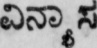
ವಿನ್ಯಾಸ
